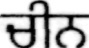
ਚੀਨ
